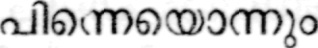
പിന്നെയൊന്നും
